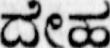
ದೇಹ
